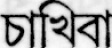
চাখিবা
